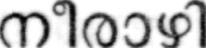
നീരാഴി
